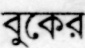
বুকের
